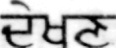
ਦੇਖਣ
